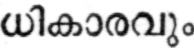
ധികാരവും
